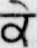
ਕੇ
